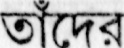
তাঁদের
